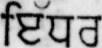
ਇੱਧਰ
